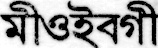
মীওইবগী
